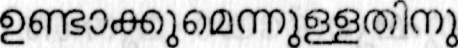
ഉണ്ടാക്കുമെന്നുള്ളതിനു
